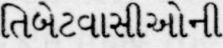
તિબેટવાસીઓની
